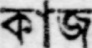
কাজ
